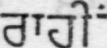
ਰਾਹੀਂ
